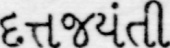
દત્તજંયતી
